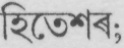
হিতেশৰ;
